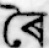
ৰৈ
